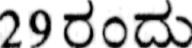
29ರಂದು
